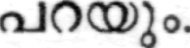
പറയും.
